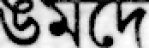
ঙমদে
